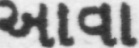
આવા
